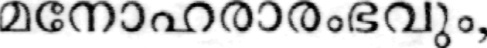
മനോഹരാരംഭവും,
